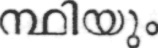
ന്ഥിയും
